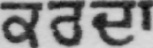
ਕਰਦਾ
